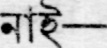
নাই—
